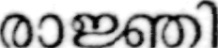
രാജ്ഞി
